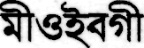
মীওইবগী
